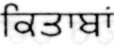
ਕਿਤਾਬਾਂ
